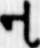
ન
